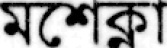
মশেক্না
